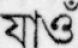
যাওঁ
